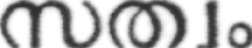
സത്വം
